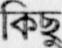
কিছু
